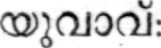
യുവാവ്:
